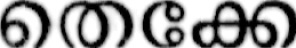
തെക്കേ
